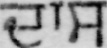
ਦਾਸ
